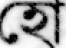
হো
